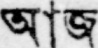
আজ
